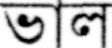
ভাল
